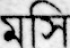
মসি
